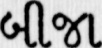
બીજા
